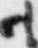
ન
